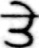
ਤੇ
